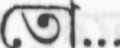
তো...
